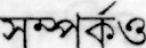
সম্পর্কও
